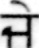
ਜੇ
